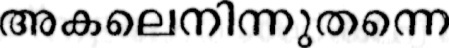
അകലെനിന്നുതന്നെ
